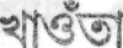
খাওঁতা
